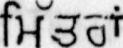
ਮਿੱਤਰਾਂ
